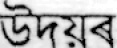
উদয়ৰ
